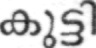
കുട്ടി
